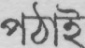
পঠাই
